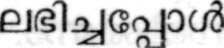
ലഭിച്ചപ്പോള്‍
